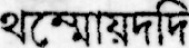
থম্মোয়দদি
